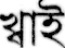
খ্বাই
